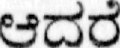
ಆದರೆ
